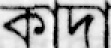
কাদা
